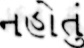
નહોતું
